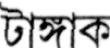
টাঙ্গাক
